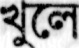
খুলে
